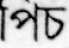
পিচ
